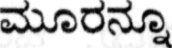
ಮೂರನ್ನೂ
